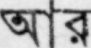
আর
